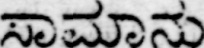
ಸಾಮಾನು
